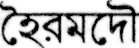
হৈরমদৌ
